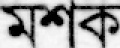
মশক
